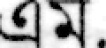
এম.
